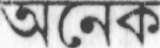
অনেক
